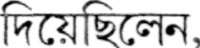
দিয়েছিলেন,
